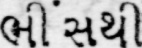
ભીંસથી
